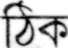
ঠিক
